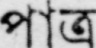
পাত্র
